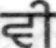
ਵੀ
